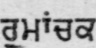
ਰੁਮਾਂਚਕ
